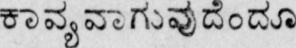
ಕಾವ್ಯವಾಗುವುದೆಂದೂ
